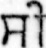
ਸੀ
